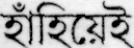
হাঁহিয়েই
